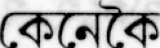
কেনেকৈ
